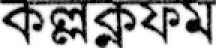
কল্লক্নফম
